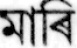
মাৰি
